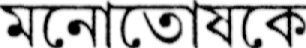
মনোতোষকে
